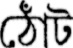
ঠোঁট
